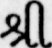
શ્રી
